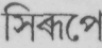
সিৰূপে
